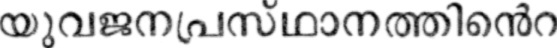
യുവജനപ്രസ്ഥാനത്തിന്റെ
